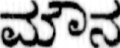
ಮೌನ
